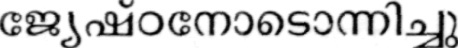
ജ്യേഷ്ഠനോടൊന്നിച്ചു
